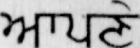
ਆਪਣੇ
